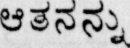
ಆತನನ್ನು
